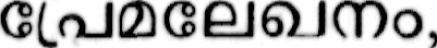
പ്രേമലേഖനം,
